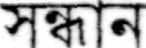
সন্ধান
